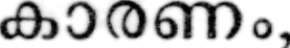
കാരണം,
